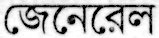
জেনেরেল
